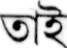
তাই
